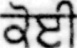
ਕੋਈ
